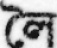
লৈ
